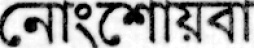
নোংশোয়বা
